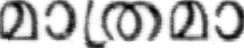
മാത്രമാ
